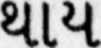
થાય
